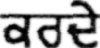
ਕਰਦੇ
